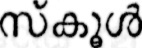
സ്കൂള്‍
